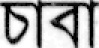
চাবা
